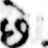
છે.
